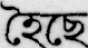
হৈছে
